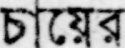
চায়ের
